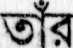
তাঁর
